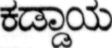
ಕಡ್ಡಾಯ
